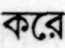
করে
